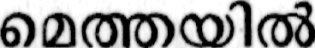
മെത്തയില്‍
